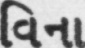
વિના
